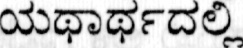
ಯಥಾರ್ಥದಲ್ಲಿ
